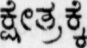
ಕ್ಷೇತ್ರಕ್ಕೆ
